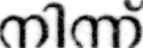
നിന്ന്
